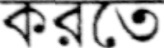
করতে
